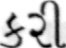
કરી.
